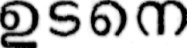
ഉടനെ
